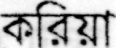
করিয়া
